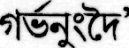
গর্ভনুংদে’
